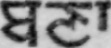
ਬਣਾ
